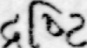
દ્રષ્ટિ
